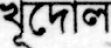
খূদোল
